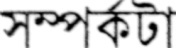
সম্পর্কটা
